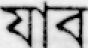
যাব
